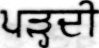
ਪੜ੍ਹਦੀ
